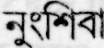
নুংশিবা
